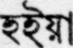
হইয়া
